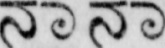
ನಾನಾ
